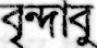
বৃন্দাবু
